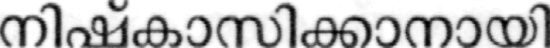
നിഷ്കാസിക്കാനായി
